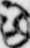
છે
